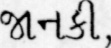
જાનકી,
